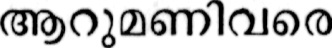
ആറുമണിവരെ
